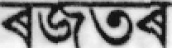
ৰজতৰ
